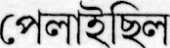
পেলাইছিল
